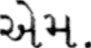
એમ.
